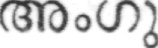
അംഗു
